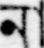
না
